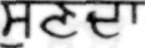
ਸੁਣਦਾ
